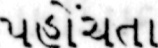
પહોંચતા
